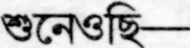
শুনেওছি–
